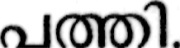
പത്തി.
